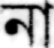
না
